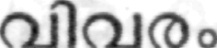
വിവരം
